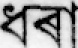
ধৰা
